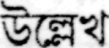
উল্লেখ
